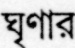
ঘৃণার
